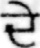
ਦੇ
